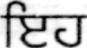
ਇਹ
